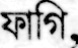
ফগি,
